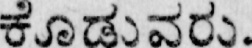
ಕೊಡುವರು.
